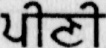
ਪੀਣੀ
